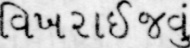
વિખરાઈજવું
